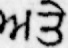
ਅਤੇ
